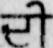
ਦੀ
